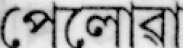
পেলোৱা
